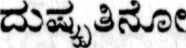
ದುಷ್ಕೃತಿನೋ
